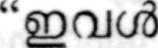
“ഇവള്‍
